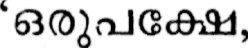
'ഒരുപക്ഷേ,
